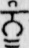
ਨੂੰ
